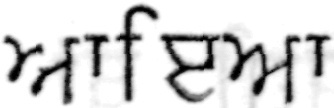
ਆਇਆ
